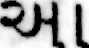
આ
